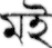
মই
